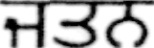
ਜਤਨ
